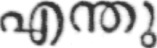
എന്തു
